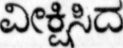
ವೀಕ್ಷಿಸಿದ
